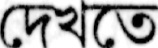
দেখতে
